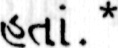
હતાં.✶
